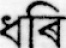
ধৰি
